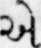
એ
